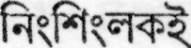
নিংশিংলকই
